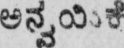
ಅನ್ವಯಿಕೆ
